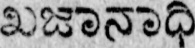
ಖಜಾನಾಧಿ
